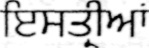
ਇਸਤ੍ਰੀਆਂ
